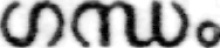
ഗന്ധം
